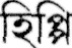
হিপ্পি
